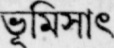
ভূমিসাৎ
